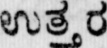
ಉತ್ತರ
